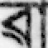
ৱা
